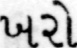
ખરો
